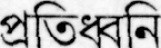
প্রতিধ্বনি
